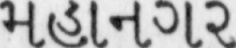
મહાનગર
